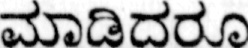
ಮಾಡಿದರೂ
